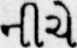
નીચે
